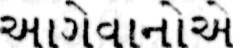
આગેવાનોએ
